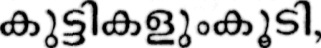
കുട്ടികളുംകൂടി,
